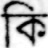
কি
